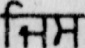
ਜਿਸ
